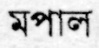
মপাল
